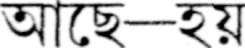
আছে–হয়
